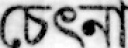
চেৎনা
